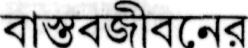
বাস্তবজীবনের
